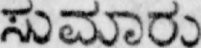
ಸುಮಾರು
